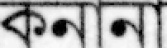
কনানা
